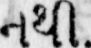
નથી.
